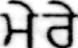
ਮੇਰੇ
